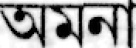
অমনা
